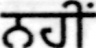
ਨਹੀਂ
